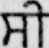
ਸੀ
